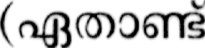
(ഏതാണ്ട്
